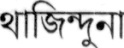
থাজিন্দুনা
